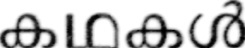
കഥകള്‍
